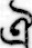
ঐ
